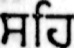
ਸਹਿ
